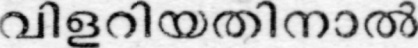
വിളറിയതിനാല്‍
